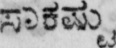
ಸಾಕಷ್ಟು
